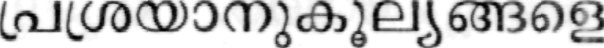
പ്രശ്രയാനുകൂല്യങ്ങളെ
